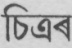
চিত্ৰৰ
